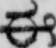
ಈ
